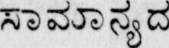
ಸಾಮಾನ್ಯದ
